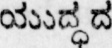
ಯುದ್ಧದ
